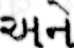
અને
